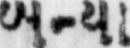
બન્યા
